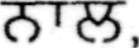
ਨਾਲ,
